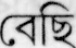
বেছি
